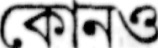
কোনও
